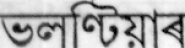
ভলণ্টিয়াৰ
